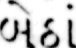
બેઠાં
